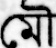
মৌ
